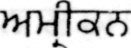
ਅਮ੍ਰੀਕਨ
